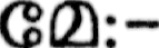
മേ:-
